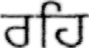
ਰਹਿ
